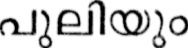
പുലിയും
